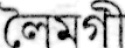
লৈমগী
